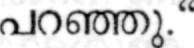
പറഞ്ഞു."
